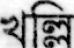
খল্লি
